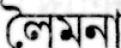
লৈমনা
